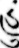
હું
